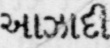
આઝાદી
